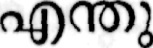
എന്തു
